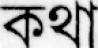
কথা
